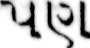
પણ
